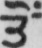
ਤੋਂ
